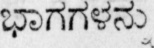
ಭಾಗಗಳನ್ನು
